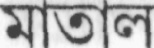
মাতাল
